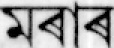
মৰাৰ
